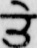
ਤੇ
